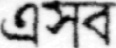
এসব
